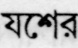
যশের
